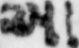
આ
